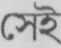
সেই
